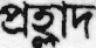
প্ৰহ্লাদ
